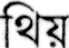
থিয়
